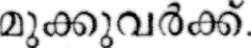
മുക്കുവര്‍ക്ക്.
